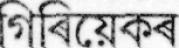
গিৰিয়েকৰ
